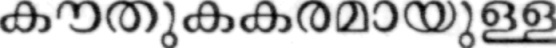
കൌതുകകരമായുള്ള
